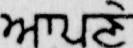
ਆਪਣੇ
